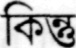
কিন্তু
